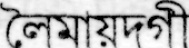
লৈমায়দগী
